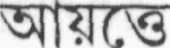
আয়ত্তে
